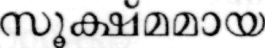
സൂക്ഷ്മമായ
